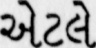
એટલે
